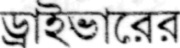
ড্রাইভারের
